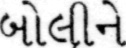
બોલીને
